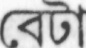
বেটা
